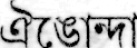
ঐঙোন্দা
